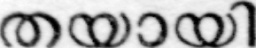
തയായി
